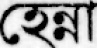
হেন্না
